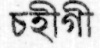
চহীগী
